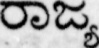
ರಾಜ್ಯ
